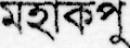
মহাকপু
